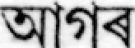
আগৰ
